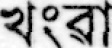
খংৱা
